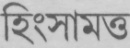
হিংসামত্ত
